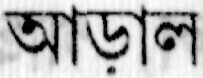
আড়াল
